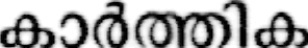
കാര്‍ത്തിക
